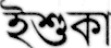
ইশুকা
